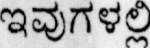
ಇವುಗಳಲ್ಲಿ
